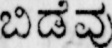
ಬಿಡೆವು
